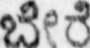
ಬೇರೆ
